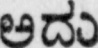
ಅದು
